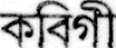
কবিগী
